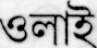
ওলাই
